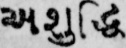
અશુદ્ધિ
